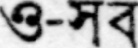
ও-সব
